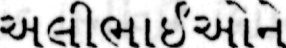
અલીભાઈઓને
